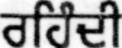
ਰਹਿੰਦੀ
